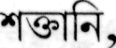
শক্তানি,
